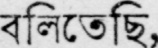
বলিতেছি,
